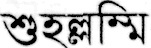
শুহল্লম্মি
